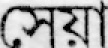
সেয়া
